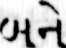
બને
